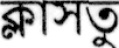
ক্লাসতু
